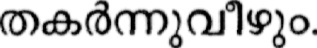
തകര്‍ന്നുവീഴും.
